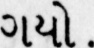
ગયો.
